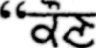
''ਕੌਣ
